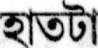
হাতটা
